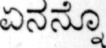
ಏನನ್ನೊ
